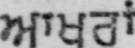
ਆਖਰਾਂ
